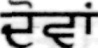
ਦੋਵਾਂ
